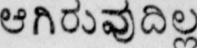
ಆಗಿರುವುದಿಲ್ಲ
